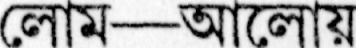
লোম–আলোয়
